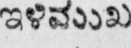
ಇಳಿಮುಖ
